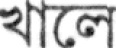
খালে
